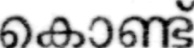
കൊണ്ട്
